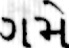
ગમે
